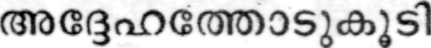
അദ്ദേഹത്തോടുകൂടി
